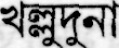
খল্লুদুনা
